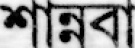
শান্নবা
